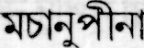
মচানুপীনা
